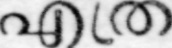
എത്ര
